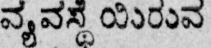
ವ್ಯವಸ್ಥೆಯಿರುವ
